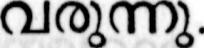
വരുന്നു.
